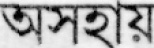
অসহায়
